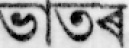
ভাতৰ
